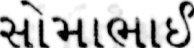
સોમાભાઈ
